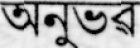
অনুভৱ
